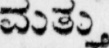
ಮತ್ತು
